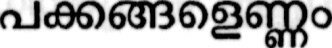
പക്കങ്ങളെണ്ണം
